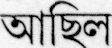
আছিল
